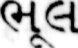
ભૂલ
